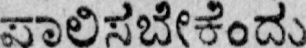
ಪಾಲಿಸಬೇಕೇಂದು
